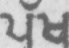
ਪੱਖ
